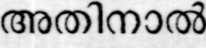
അതിനാല്‍
